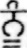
ਨੂੰ
